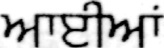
ਆਈਆਂ
